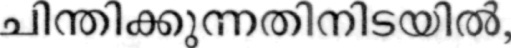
ചിന്തിക്കുന്നതിനിടയില്‍,
